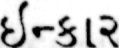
ઇન્કાર
